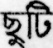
ছুটি
